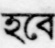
হবে
